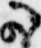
જે
